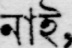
নাই,
